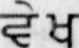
ਵੇਖ
